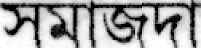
সমাজদা
